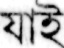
যাই
